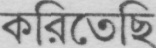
করিতেছি
